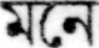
মনে
